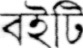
বইটি
